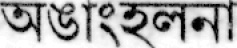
অঙাংহলনা
